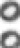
ঃ
